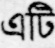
এটি
